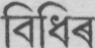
বিধিৰ
